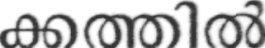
ക്കത്തില്‍
